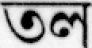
তল
